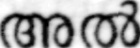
അല്‍
